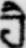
ਹੈ
